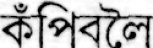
কঁপিবলৈ
